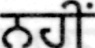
ਨਹੀਂ
